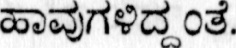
ಹಾವುಗಳಿದ್ದಂತೆ.
